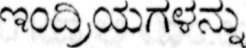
ಇಂದ್ರಿಯಗಳನ್ನು
